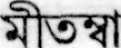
মীতম্বা
